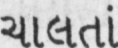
ચાલતાં
